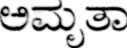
ಅಮೃತಾ
